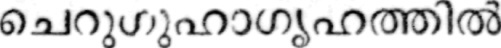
ചെറുഗുഹാഗൃഹത്തില്‍
